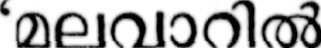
‘മലവാറില്‍
